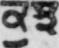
ਕੁਝ
